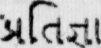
પ્રતિજ્ઞા
